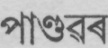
পাণ্ডৱৰ
